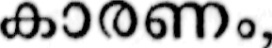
കാരണം,
